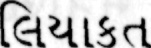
લિયાકત
